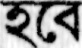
হবে
